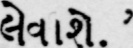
લેવાશે'
